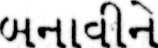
બનાવીને
